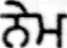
ਨੇਮ
